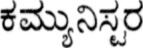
ಕಮ್ಯುನಿಸ್ಟರ
